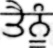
ਤੈਨੂੰ
